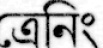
ত্রেনিং
